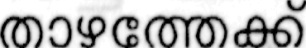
താഴത്തേക്ക്
